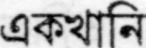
একখানি
